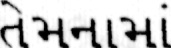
તેમનામાં
